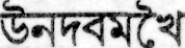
উনদবমখৈ
